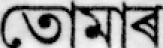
তোমাৰ
